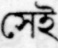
সেই
